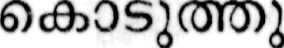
കൊടുത്തു
